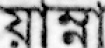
য়াম্না
